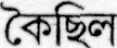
কৈছিল
